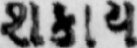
શકાય
